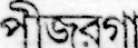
পীজরগা
